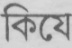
কিযে
